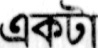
একটা
